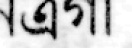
নত্রগা
